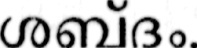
ശബ്ദം.
